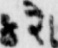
કરો
